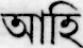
আহি
